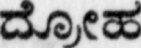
ದ್ರೋಹ
